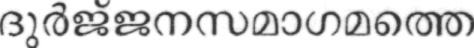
ദുര്‍ജ്ജനസമാഗമത്തെ
